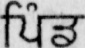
ਪਿੰਡ
